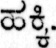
ಹಕ್ಕಿ.
